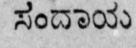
ಸಂದಾಯ
